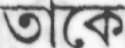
তাকে
